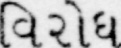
વિરોધ
